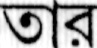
তার
